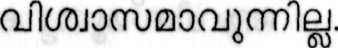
വിശ്വാസമാവുന്നില്ല.
